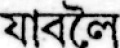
যাবলৈ
